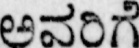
ಅವರಿಗೆ
